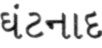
ઘંટનાદ
